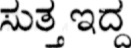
ಸುತ್ತಇದ್ದ
